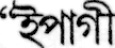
“ইপাগী
